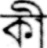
কী
